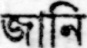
জানি
